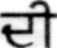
ਦੀ
